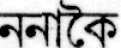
ননাকৈ
